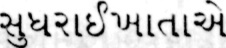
સુધરાઈખાતાએ
